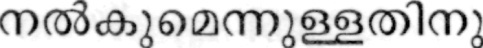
നല്‍കുമെന്നുള്ളതിനു
